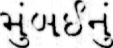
મુંબઈનું
